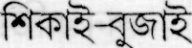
শিকাই-বুজাই
